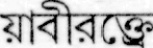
য়াবীরক্ত্রে
